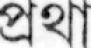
প্রথা
